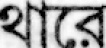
থারে
